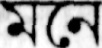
মনে
